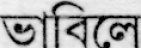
ভাবিলে
